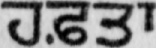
ਹਫ਼ਤਾ
